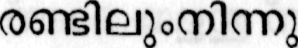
രണ്ടിലുംനിന്നു
